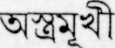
অস্ত্রমূখী
